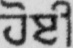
ਹੋਈ
